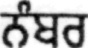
ਨੰਬਰ
